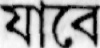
যাবে
